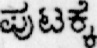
ಪುಟಕ್ಕೆ
